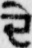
ਦੇ
